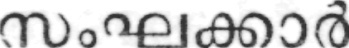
സംഘക്കാര്‍
